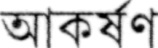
আকর্ষণ
